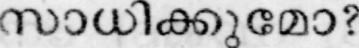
സാധിക്കുമോ?
